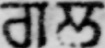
ਗਲ
